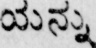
ಯನ್ನು
